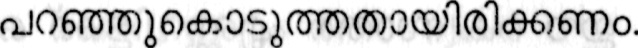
പറഞ്ഞുകൊടുത്തതായിരിക്കണം.
